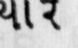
ત્યારે
